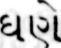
ઘણે
